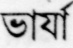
ভার্যা
